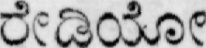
ರೇಡಿಯೋ
